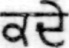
ਕਦੇ
